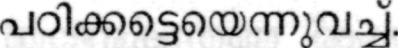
പഠിക്കട്ടെയെന്നുവച്ച്.
